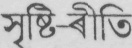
সৃষ্টি-ৰীতি
